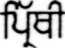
ਪ੍ਰਿੱਥੀ
